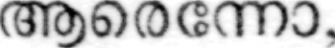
ആരെന്നോ,
